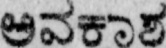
ಅವಕಾಶ
